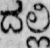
ದಲ್ಲಿ
